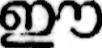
ഈ
